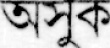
অসুক
